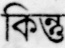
কিন্তু
